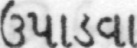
ઉપાડવા
